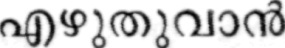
എഴുതുവാന്‍
